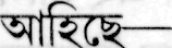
আহিছে-
